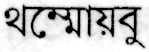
থম্মোয়বু
